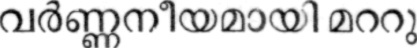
വര്‍ണ്ണനീയമായിമററു
